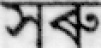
সৰু
